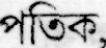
পতিক,
